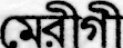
মেরীগী
